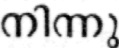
നിന്നു
